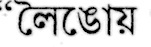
“লৈঙোয়
